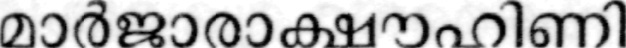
മാര്‍ജാരാക്ഷൌഹിണി
